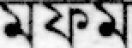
মফম
